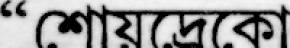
“শোয়দ্রেকো
